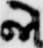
જો
